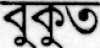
বুকুত
